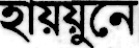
হায়য়ুনে
